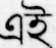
এই
